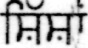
ਸ਼ਿੱਸ਼ਾਂ
